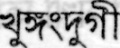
খুঙ্গংদুগী
